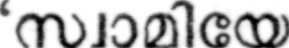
‘സ്വാമിയേ
